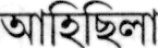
আহিছিলা
